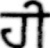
ਹੀ
